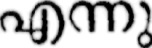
എന്നു
